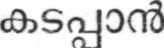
കടപ്പാന്‍
